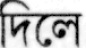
দিলে
